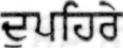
ਦੁਪਹਿਰੇ
